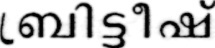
ബ്രിട്ടീഷ്
